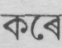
কৰে
